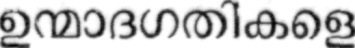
ഉന്മാദഗതികളെ
